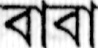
বাবা
